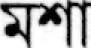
মশা
